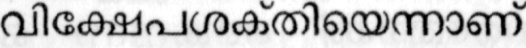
വിക്ഷേപശക്തിയെന്നാണ്
